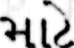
માટે
